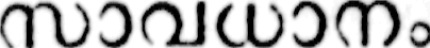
സാവധാനം
